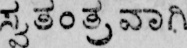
ಸ್ವತಂತ್ರವಾಗಿ
